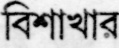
বিশাখার
